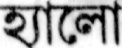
হ্যালো
